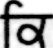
ਕਿ
